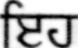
ਇਹ
